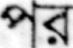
পর
